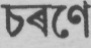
চৰণে
